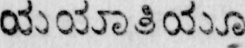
ಯಯಾತಿಯೂ
